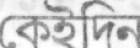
কেইদিন
